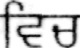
ਵਿਚ
